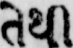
તેથી
